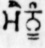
ਮੈਨੂੰ
